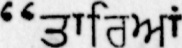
''ਤਾਰਿਆਂ
